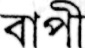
বাপী
